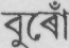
বুৰোঁ
